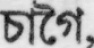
চাগৈ,
